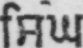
ਸਿੰਘ
